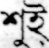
শুই
